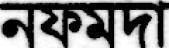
নফমদা
